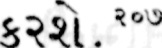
કરશે.૨૦૭
